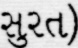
સુરત)
